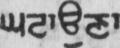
ਘਟਾਉਣਾ
